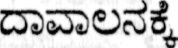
ದಾವಾಲನಕ್ಕೆ
